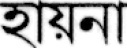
হায়না
